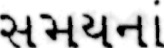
સમયમાં
